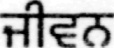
ਜੀਵਨ
